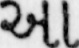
આ
